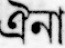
ঐনা
